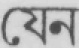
যেন
